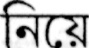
নিয়ে
